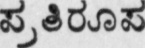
ಪ್ರತಿರೂಪ
